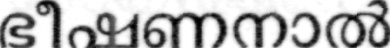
ഭീഷണനാല്‍
